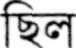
ছিল
